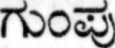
ಗುಂಪು
